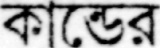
কান্ডের
